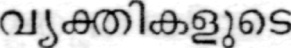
വ്യക്തികളുടെ
